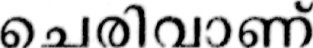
ചെരിവാണ്
